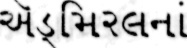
ઍડમિરલનાં
